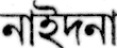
নাইদনা
